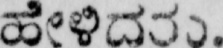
ಹೇಳಿದರು.
